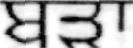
ਬੜਾ
